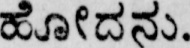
ಹೋದನು.
